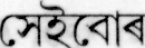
সেইবোৰ
